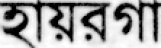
হায়রগা
